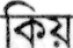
কিয়
